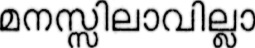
മനസ്സിലാവില്ലാ
